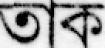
তাক
